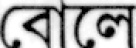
বোলে
